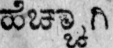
ಹೆಚ್ಚಾಗಿ
